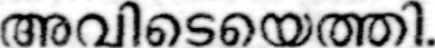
അവിടെയെത്തി.
